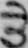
ਤੇ
